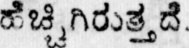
ಹೆಚ್ಚಿಗಿರುತ್ತದೆ.
